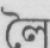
লৈ
